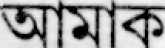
আমাক
